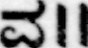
ವ||
